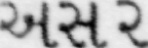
અસર
